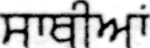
ਸਾਥੀਆਂ
